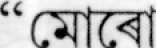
"মোৰো
